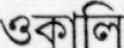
ওকালি
